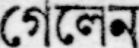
গেলেন
